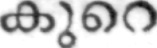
കുറെ
